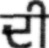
ਦੀ
